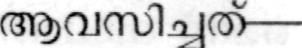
ആവസിച്ചത്-
